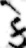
કે
